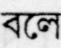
বলে
